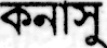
কনাসু
